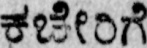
ಕಚೇರಿಗೆ
